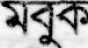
মবুক
